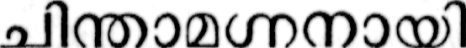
ചിന്താമഗ്നനായി
